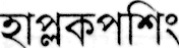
হাপলকপশিং
